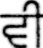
ਵੀ
